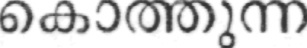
കൊത്തുന്ന
